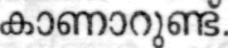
കാണാറുണ്ട്.
